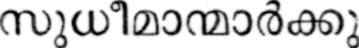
സുധീമാന്മാര്‍ക്കു
